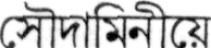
সৌদামিনীয়ে
